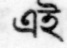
এই
